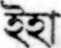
ইহা
